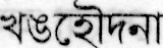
খঙহৌদনা
